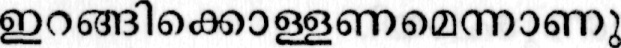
ഇറങ്ങിക്കൊള്ളണമെന്നാണു
